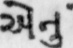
એનું
